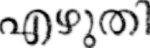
എഴുതി
